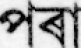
পৰা
